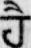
ਹੈ
